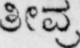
ತೀವ್ರ
